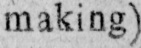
making)
